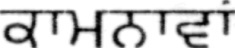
ਕਾਮਨਾਵਾਂ
